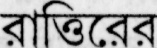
রাত্তিরের
